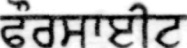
ਫੌਰਸਾਈਟ
